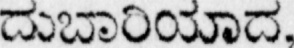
ದುಬಾರಿಯಾದ,
